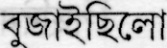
বুজাইছিলো
